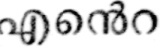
എന്റെ
